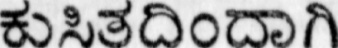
ಕುಸಿತದಿಂದಾಗಿ
